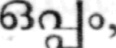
ഒപ്പം,
